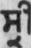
ਸ੍ਰੀ
